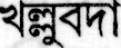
খল্লুবদা
